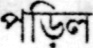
পড়িল
